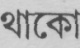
থাকো
